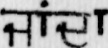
ਜਾਂਦਾ
